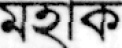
মহাক
